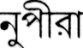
নুপীরা
